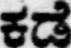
ಕಡೆ
